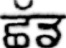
ਛੱਡ
